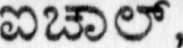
ಐಚಾಲ್,
